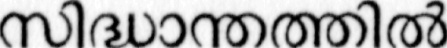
സിദ്ധാന്തത്തില്‍
